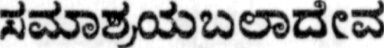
ಸಮಾಶ್ರಯಬಲಾದೇವ
